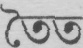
তৈত
